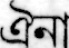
ঐনা
